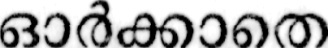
ഓര്‍ക്കാതെ
